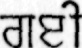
ਗਈ
